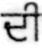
ਦੀ
